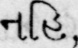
નહિ,
